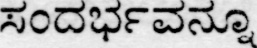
ಸಂದರ್ಭವನ್ನೂ
